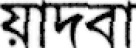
য়াদবা
